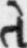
તે
